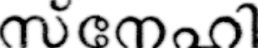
സ്നേഹി
